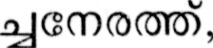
ച്ചനേരത്ത്,
